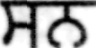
ਸਨ
